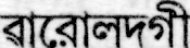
ৱারোলদগী
